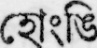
হোংঙি
